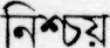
নিশ্চয়
